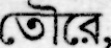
তৌরে,
